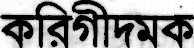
করিগীদমক
